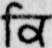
ਕਿ
